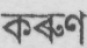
কৰুণ
